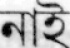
নাই
